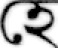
হে
